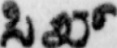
ಸಿಖ್
